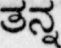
ತನ್ನ
